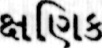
ક્ષણિક
